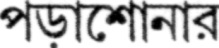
পড়াশোনার
